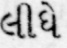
લીધે
